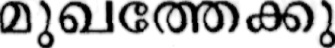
മുഖത്തേക്കു
